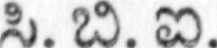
ಸಿ.ಬಿ.ಐ.
